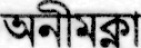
অনীমক্না
